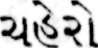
ચહેરો
